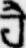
ਹੈ
